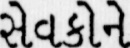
સેવકોને
